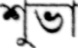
শুভা
